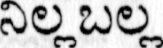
ನಿಲ್ಲಬಲ್ಲ
